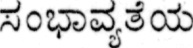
ಸಂಭಾವ್ಯತೆಯ
